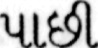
પાછી
